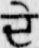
ਦੇ
